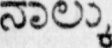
ನಾಲ್ಕು
